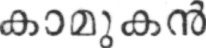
കാമുകന്‍
